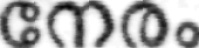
നേരം
